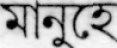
মানুহে
